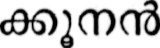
ക്കൂനന്‍
